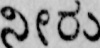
ನೀರು
